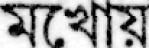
মখোয়
